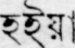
হইয়া
